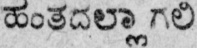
ಹಂತದಲ್ಲಾಗಲಿ
